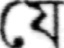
যে
